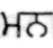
ਮਨ
